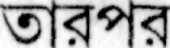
তারপর
